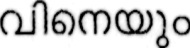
വിനെയും
